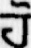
ਹੋ
